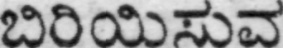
ಬಿರಿಯಿಸುವ
